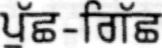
ਪੁੱਛ-ਗਿੱਛ
